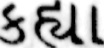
કહ્યા
